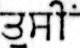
ਤੁਸੀਂ
